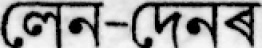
লেন-দেনৰ
